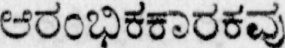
ಆರಂಭಿಕಕಾರಕವು
